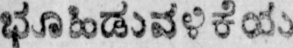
ಭೂಹಿಡುವಳಿಕೆಯ
